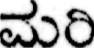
ಮರಿ
